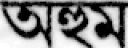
অহুম
